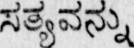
ಸತ್ಯವನ್ನು
